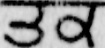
ਤਕ
